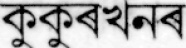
কুকুৰখনৰ
